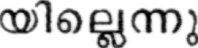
യില്ലെന്നു
